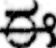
ಈ
